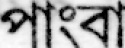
পাংবা
